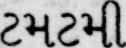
ટમટમી
